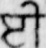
ਈ
